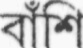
বাঁশি
